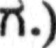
ಗೆ.)
